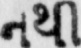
નથી
